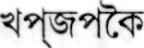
খপ‌্জপকৈ
